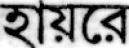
হায়রে
